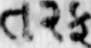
તરફ
